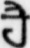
ਹੈ
